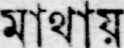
মাথায়
